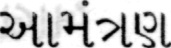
આમંત્રણ
